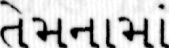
તેમનામાં
